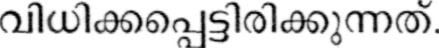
വിധിക്കപ്പെട്ടിരിക്കുന്നത്.
